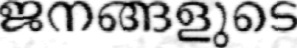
ജനങ്ങളുടെ
